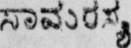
ಸಾಮರಸ್ಯ
